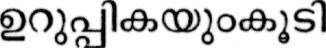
ഉറുപ്പികയുംകൂടി
